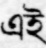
এই
